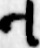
ન
